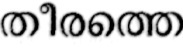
തീരത്തെ
